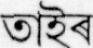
তাইৰ
